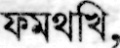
ফমথখি,
